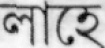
লাহে
